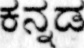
ಕನ್ನಡ
